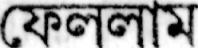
ফেললাম
